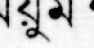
ময়ুম
